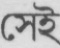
সেই
